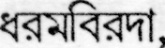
ধরমবিরদা,
